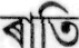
ৰাতি
